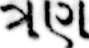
ત્રણ
